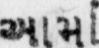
આમાં
